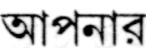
আপনার
